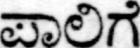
ಪಾಲಿಗೆ
